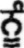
ਨੂੰ
